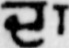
ਦਾ
